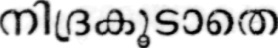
നിദ്രകൂടാതെ
